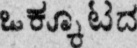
ಒಕ್ಕೂಟದ
